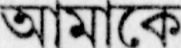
আমাকে
